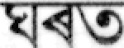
ঘৰত
